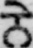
ਨੇ
